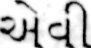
એવી
